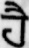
ਹੈ
